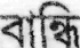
বান্ধি
